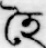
হৈ
